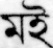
মই
